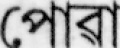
পোৱা
